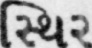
સ્થિર
